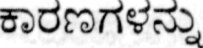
ಕಾರಣಗಳನ್ನು
